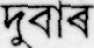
দুবাৰ
